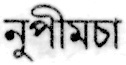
নুপীমচা
